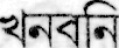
খনবনি
